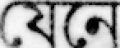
যেনে
